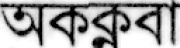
অকক্নবা
